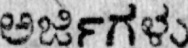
ಅರ್ಜಿಗಳು
